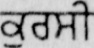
ਕੁਰਸੀ
